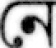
নে
